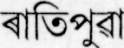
ৰাতিপুৱা
